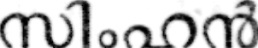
സിംഹന്‍
